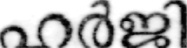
ഹര്‍ജി
